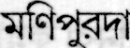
মণিপুরদা
